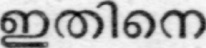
ഇതിനെ
